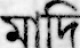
মাদি
